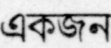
একজন
